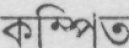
কম্পিত
